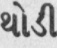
થોડી
